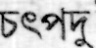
চৎপদু
